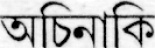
অচিনাকি
